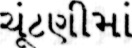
ચૂંટણીમાં
